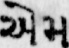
એમ
